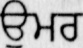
ਉਮਰ
